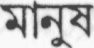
মানুষ
